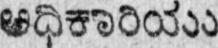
ಅಧಿಕಾರಿಯು
